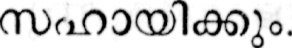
സഹായിക്കും.
